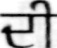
ਦੀ
